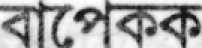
বাপেকক
